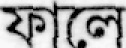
ফালে
